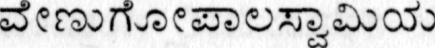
ವೇಣುಗೋಪಾಲಸ್ವಾಮಿಯ
